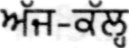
ਅੱਜ-ਕੱਲ੍ਹ
